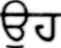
ਉਹ
